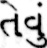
તેવું
